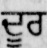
ਦੂਰ
